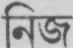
নিজ
